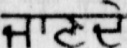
ਜਾਣਦੇ
